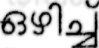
ഒഴിച്ച്
